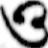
ও
